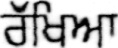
ਰੱਖਿਆ
